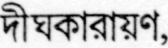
দীঘকারায়ণ,
